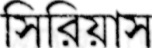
সিরিয়াস
